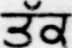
ਤੱਕ
